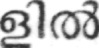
ളില്‍
